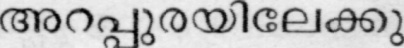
അറപ്പുരയിലേക്കു
